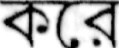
করে
